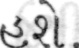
હશે.
